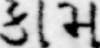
કામ
